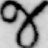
જ
